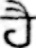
ਹੈ
